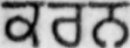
ਕਰਨ
